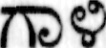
ಗಾಳಿ
